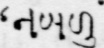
'નબળું
